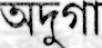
অদুগা
